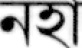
নহা
